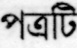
পত্রটি
